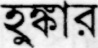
হুঙ্কার
